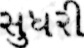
સુધરી
